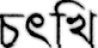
চৎখি
